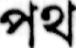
পথ
